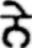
ਨੇ
